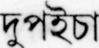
দুপইচা
